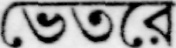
ভেতরে
